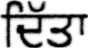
ਦਿੱਤਾ
